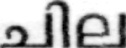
ചില
